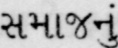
સમાજનું
